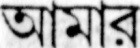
আমার
